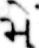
મેં
